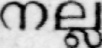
നല്ല
